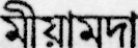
মীয়ামদা
